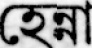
হেন্না
